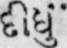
દીધું
